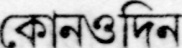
কোনওদিন
